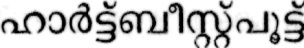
ഹാര്‍ട്ട്ബീസ്റ്റ്പൂട്ട്
